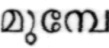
മുമ്പേ
